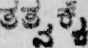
ತತ್ವಕ್ಕೆ
